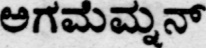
ಅಗಮೆಮ್ನನ್
